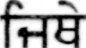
ਜਿਥੇ
